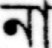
না
